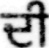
ਦੀ
